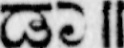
ಡಾ||
